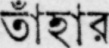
তাঁহার
